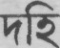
দহি
